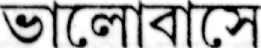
ভালোবাসে
